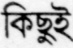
কিছুই
